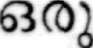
ഒരു
